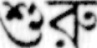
শুরু
